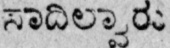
ಸಾದಿಲ್ವಾರು
